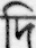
দি
